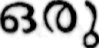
ഒരു
